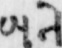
બને
